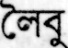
লৈবু
